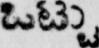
ಒಟ್ಟು
